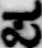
ಪ
